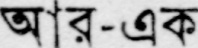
আর-এক
